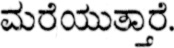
ಮರೆಯುತ್ತಾರೆ.
